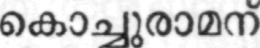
കൊച്ചുരാമന്
